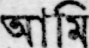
আমি
